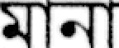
মানা
